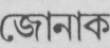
জোনাক
